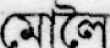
মোলৈ
